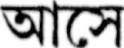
আসে
